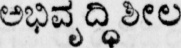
ಅಭಿವೃದ್ಧಿಶೀಲ
